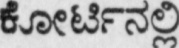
ಕೋರ್ಟಿನಲ್ಲಿ
